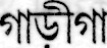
গাড়ীগা
